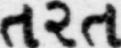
તરત
